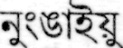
নুংঙাইয়ু
